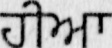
ਹੀਆ
